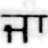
ਜਾ
